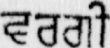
ਵਰਗੀ
